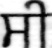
ਸੀ
